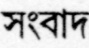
সংবাদ
